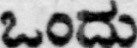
ಒ೦ದು
